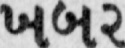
ખબર
